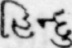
હિન્દુ
